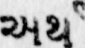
અર્થ
